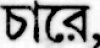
চারে,
